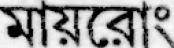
মায়রোং
